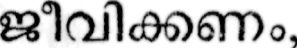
ജീവിക്കണം,
